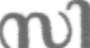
സി
